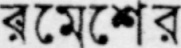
রমেশের
